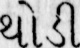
થોડી
